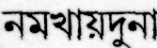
নমখায়দুনা
